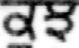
ਕੁਝ
